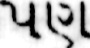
પણ
